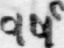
વર્ષ
